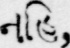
નહિ,
